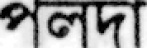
পলদা
